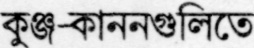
কুঞ্জ-কাননগুলিতে
